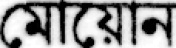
মোয়োন
